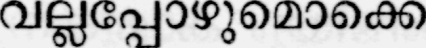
വല്ലപ്പോഴുമൊക്കെ
